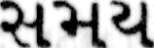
સમય
